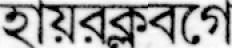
হায়রক্লবগে
